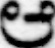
ಆ
